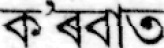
ক'ৰবাত
